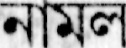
নামল
